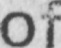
of
